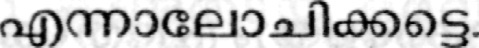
എന്നാലോചിക്കട്ടെ.
